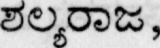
ಶಲ್ಯರಾಜ,
